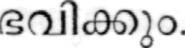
ഭവിക്കും.
